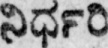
ನಿರ್ಧರಿ
